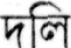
দলি
